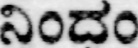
ನಿಂದಂ
